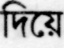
দিয়ে
